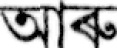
আৰু
